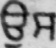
ਉਸ
